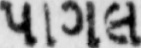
પાગલ
